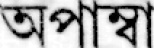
অপাম্বা
